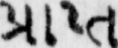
પ્રાપ્ત
